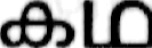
കഥ
